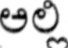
ಅಲ್ಲಿ
